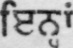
ਇਨ੍ਹਾਂ
